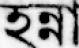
হন্না
